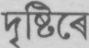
দৃষ্টিৰে
